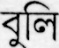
বুলি
